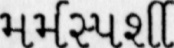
મર્મસ્પર્શી
